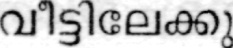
വീട്ടിലേക്കു
